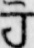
ਹੋ
